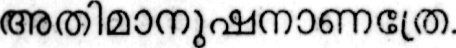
അതിമാനുഷനാണത്രേ.
